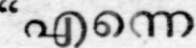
"എന്നെ
